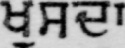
ਖੁਸਦਾ
